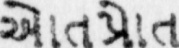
ઓતપ્રોત
